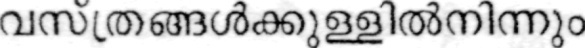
വസ്ത്രങ്ങള്‍ക്കുള്ളില്‍നിന്നും
